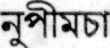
নুপীমচা
